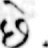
છે.
